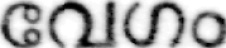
വേഗം
